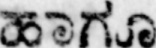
ಹಾಗೂ
